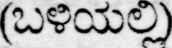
(ಬಳಿಯಲ್ಲಿ)
